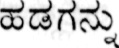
ಹಡಗನ್ನು
